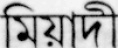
মিয়াদী
